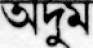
অদুম
